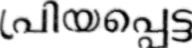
പ്രിയപ്പെട്ട
